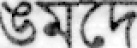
ঙমদে
